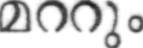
മററും
